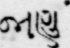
જાણું
